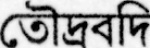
তৌদ্রবদি
